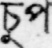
চুপ
